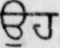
ਉਹ
